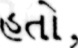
હતો,
